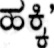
ಹಕ್ಕಿ'
